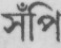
সঁপি
